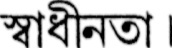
স্বাধীনতা।
